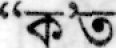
"ক'ত
